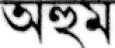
অহুম
